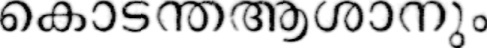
കൊടന്തആശാനും
